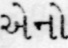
એનો
